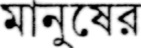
মানুষের
